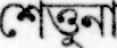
শেত্তুনা
